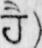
ਹੈ)
